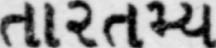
તારતમ્ય
